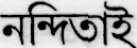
নন্দিতাই
